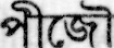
পীজৌ
